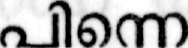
പിന്നെ
